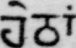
ਹੇਠਾਂ
